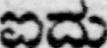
ಐದು
